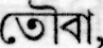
তৌবা,
